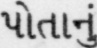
પોતાનું
